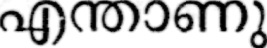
എന്താണു
